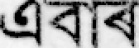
এবাৰ
